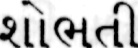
શોભતી
